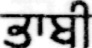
ਭਾਬੀ
